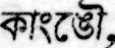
কাংহৌ,
